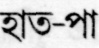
হাত-পা
